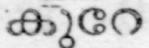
കുറേ
